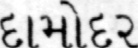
દામોદર
